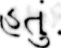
હતું.
